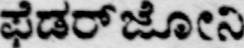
ಫೆಡರ್‌ಜೋನಿ
